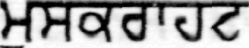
ਮੁਸਕਰਾਹਟ
